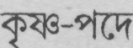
কৃষ্ণ-পদে
